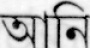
আনি
